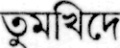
তুমখিদে
